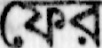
ফের
